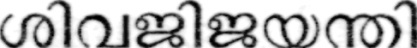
ശിവജിജയന്തി
